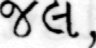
જલ,
